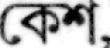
কেশ,
